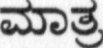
ಮಾತ್ರ
